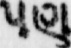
પણ
